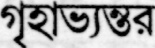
গৃহাভ্যন্তর
